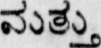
ಮತ್ತು
